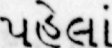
પહેલાં
